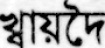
খ্বায়দৈ
